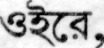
ওইরে,
